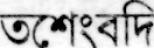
তশেংবদি
